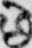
છે
